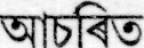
আচৰিত
